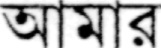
আমার
